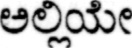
ಅಲ್ಲಿಯೇ
